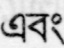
এবং
